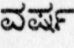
ವರ್ಷ
